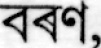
বৰণ,
